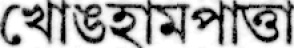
খোঙহামপাত্তা
